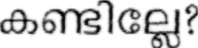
കണ്ടില്ലേ?
